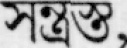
সন্ত্রস্ত,
